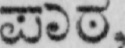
ಪಾಠ,
